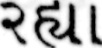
રહ્યા
